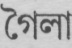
গৈলা
